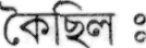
কৈছিলঃ
